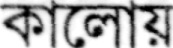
কালোয়
